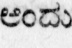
ಅಂದು
